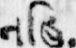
નહિ.
